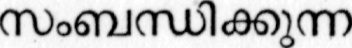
സംബന്ധിക്കുന്ന
